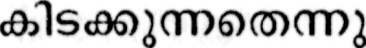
കിടക്കുന്നതെന്നു
